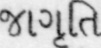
જાગૃતિ
